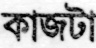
কাজটা
